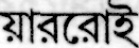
য়াররোই
